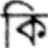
কি
